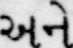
અને
